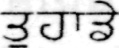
ਤੁਹਾਡੇ
